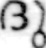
ദു
